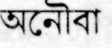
অনৌবা
